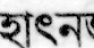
হাৎনত
